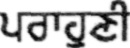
ਪਰਾਹੁਣੀ
